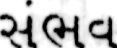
સંભવ
